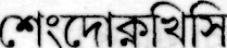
শেংদোক্নখিসি
